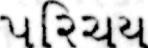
પરિચય
